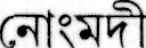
নোংমদী
